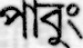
পাবুং
